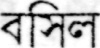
বসিল
